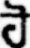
ਹੋ
